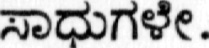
ಸಾಧುಗಳೇ.
